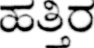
ಹತ್ತಿರ
